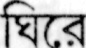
ঘিরে
